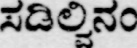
ಸಡಿಲ್ವಿನ೦
